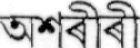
অশৰীৰী
